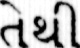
તેથી
